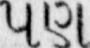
પણ
